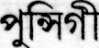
পুন্সিগী
